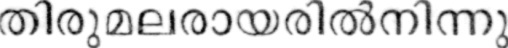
തിരുമലരായരില്‍നിന്നു
